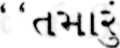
"તમારું
